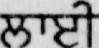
ਲਾਈ
